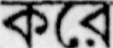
করে
